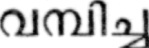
വമ്പിച്ച
